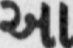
આ
